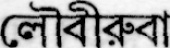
লৌবীরুবা
